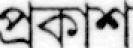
প্ৰকাশ
